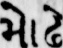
મોઢે
